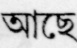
আছে
